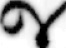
જ
